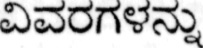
ವಿವರಗಳನ್ನು
